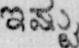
ಇಷ್ಟು
